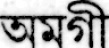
অমগী
